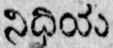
ನಿಧಿಯ
